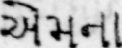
એમના
